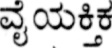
ವೈಯಕ್ತಿಕ
